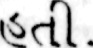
હતી.
